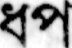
ধপ
